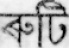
ৰুটি
